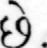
છે.
